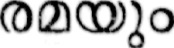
രമയും
